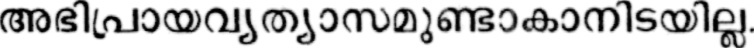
അഭിപ്രായവ്യത്യാസമുണ്ടാകാനിടയില്ല.
